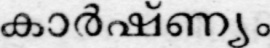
കാര്‍ഷ്ണ്യം
